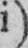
i)
